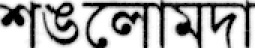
শঙলোমদা
